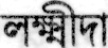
লক্ষ্মীদা
